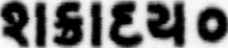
શક્રદય.
